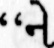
"ને
